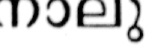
നാലു
